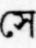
সে
